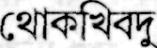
থোকখিবদু
